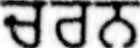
ਚਰਨ
